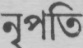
নৃপতি
